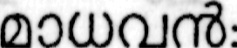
മാധവന്‍:
